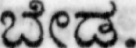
ಬೇಡ.
